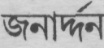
জনাৰ্দ্দন
